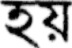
হয়
